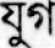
যুগ
